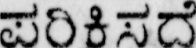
ಪರಿಕಿಸದೆ
